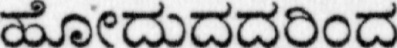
ಹೋದುದದರಿಂದ
